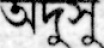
অদুসু
